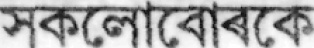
সকলোবোৰকে
